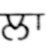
ਲਾ
